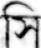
সি
